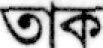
তাক
